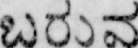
ಬರುವ
